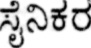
ಸೈನಿಕರ
